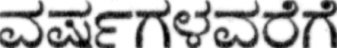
ವರ್ಷಗಳವರೆಗೆ
